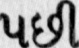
પછી
